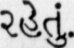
રહેતું.
